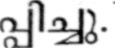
പ്പിച്ചു.
